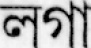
লগা
